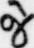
જે
